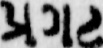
પ્રગટ
